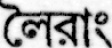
লৈরাং
